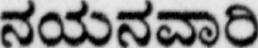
ನಯನವಾರಿ
